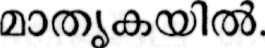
മാതൃകയില്‍.
